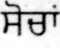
ਸੋਚਾਂ
